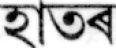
হাতৰ
